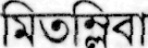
মিতম্লিবা
